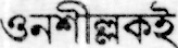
ওনশীল্লকই
